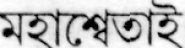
মহাশ্বেতাই
